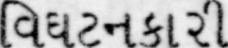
વિઘટનકારી
